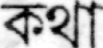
কথা
